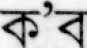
ক'ব
